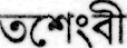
তশেংবী
